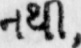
નથ
